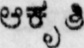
ಆಕೃತಿ
